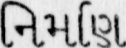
નિર્માણ
